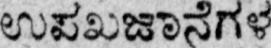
ಉಪಖಜಾನೆಗಳ
